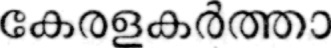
കേരളകര്‍ത്താ
